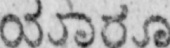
ಯಾರೂ
